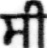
ਸੀ
